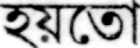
হয়তো
